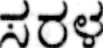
ಸರಳ
